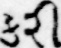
કરી
